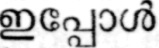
ഇപ്പോള്‍
